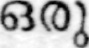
ഒരു
